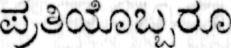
ಪ್ರತಿಯೊಬ್ಬರೂ
